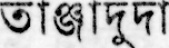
তাঞ্জাদুদা
